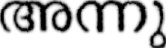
അന്നു
